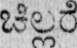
ಚಿಲ್ಲರೆ
